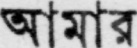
আমার
